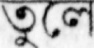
তুলে
